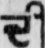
ਦੀ
